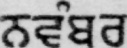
ਨਵੰਬਰ
